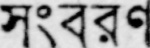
সংবরণ
